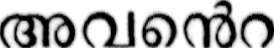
അവന്റെ
